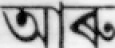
আৰু
